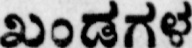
ಖಂಡಗಳ
